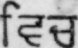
ਵਿਚ
